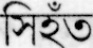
সিহঁত
